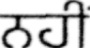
ਨਹੀਂ
